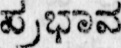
ಪ್ರಭಾವ
